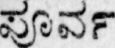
ಪೂರ್ವ
